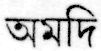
অমদি
